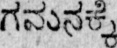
ಗಮನಕ್ಕೆ
